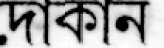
দোকান
